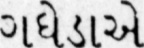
ગધેડાએ
